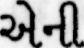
એની
